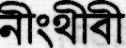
নীংথীবী
